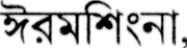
ঈরমশিংনা,
